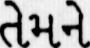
તેમને
